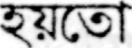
হয়তো
